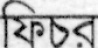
ফিচর
